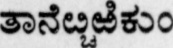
ತಾನೆೞ್ಚಱಕುಂ
